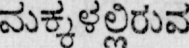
ಮಕ್ಕಳಲ್ಲಿರುವ
